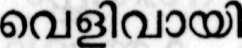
വെളിവായി
